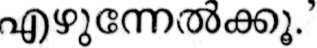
എഴുന്നേല്‍ക്കൂ.’
